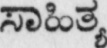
ಸಾಹಿತ್ಯ
